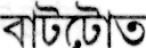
বাটটোত
